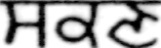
ਸਕਣ
